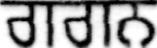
ਗਗਨ
